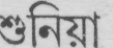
শুনিয়া
